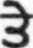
ਤੇ
